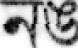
নঙ
